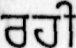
ਰਹੀ
